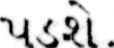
પડશે.
